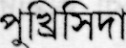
পুখ্রিসিদা
